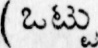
(ಒಟ್ಟು
